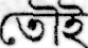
তৌই
